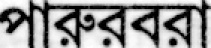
পারুরবরা
